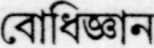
বোধিজ্ঞান
